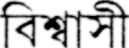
বিশ্বাসী
